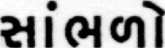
સાંભળો
